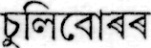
চুলিবোৰৰ
